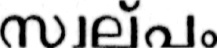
സ്വല്പം
